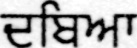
ਦਬਿਆ
